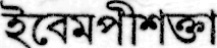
ইবেমপীশক্তা
